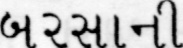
બરસાની
